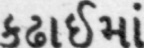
કઢાઈમાં
